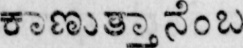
ಕಾಣುತ್ತಾನೆಂಬ
